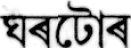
ঘৰটোৰ
